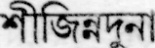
শীজিন্নদুনা
